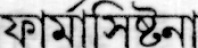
ফার্মাসিষ্টনা
